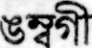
ঙম্বগী
